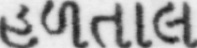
હળતાલ
